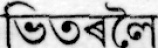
ভিতৰলৈ
